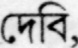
দেবি,
